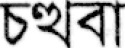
চত্থবা
